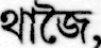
থাজৈ,
